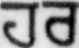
ਹਰ
